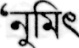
‘নুমিৎ
